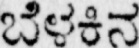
ಬೆಳಕಿನ
